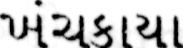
ખંચકાયા
